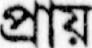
প্রায়
